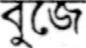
বুজে
